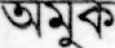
অমুক
